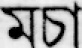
মচা
